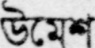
উমেশ
